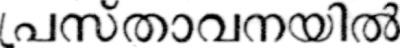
പ്രസ്താവനയില്‍
